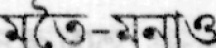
মতৈ-মনাও
